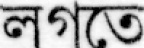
লগতে
